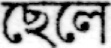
ছেলে
